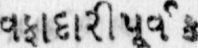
વફાદારીપૂર્વક
